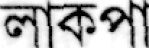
লাকপা
